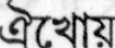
ঐখোয়
